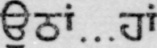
ਉਠਾ..ਹਾਂ
